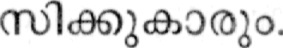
സിക്കുകാരും.
